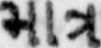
માત્ર
